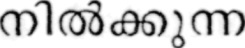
നില്‍ക്കുന്ന
